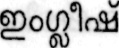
ഇംഗ്ലീഷ്
